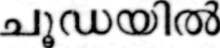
ചൂഡയില്‍
